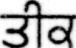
ਤੀਕ
